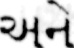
અને
